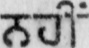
ਨਹੀਂ
